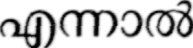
എന്നാല്‍
